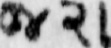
જરા
